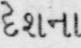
દેશના
